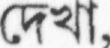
দেখা,
